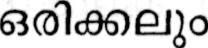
ഒരിക്കലും
